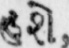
હશે,
